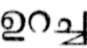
ഉറച്ച
